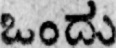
ಒಂದು
